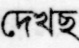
দেখছ
